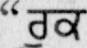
''ਰੁਕ
